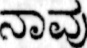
ನಾವು
